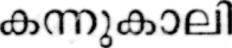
കന്നുകാലി
